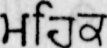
ਮਹਿਕ
